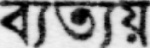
ব্যত্যয়
